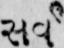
સર્વ
